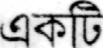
একটি
